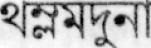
থম্লমদুনা
